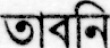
তাবনি
